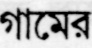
গামের
